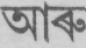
আৰু
